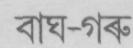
বাঘ-গৰু
